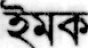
ইমক
